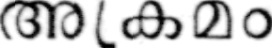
അക്രമം
